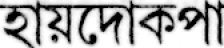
হায়দোকপা
